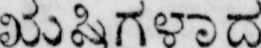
ಋಷಿಗಳಾದ
